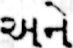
અને
